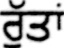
ਰੁੱਤਾਂ
